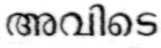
അവിടെ
